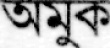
অমুক
